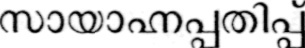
സായാഹ്നപ്പതിപ്പ്
